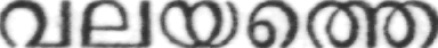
വലയത്തെ
